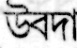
উবদা
